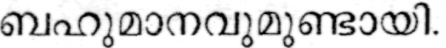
ബഹുമാനവുമുണ്ടായി.
